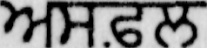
ਅਸਫ਼ਲ
